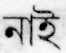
নাই
